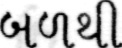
બળથી
